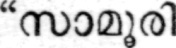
“സാമൂരി
